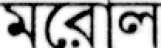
মরোল
